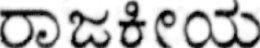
ರಾಜಕೀಯ
